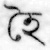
হৈ
